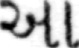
આ
